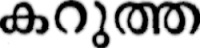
കറുത്ത
